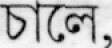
চালে,
